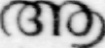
ആ
